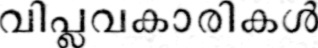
വിപ്ലവകാരികള്‍
